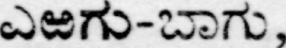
ಎಱಗು-ಬಾಗು,
